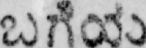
ಬಗೆಯ
